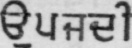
ਉਪਜਦੀ
